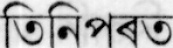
তিনিপৰত
